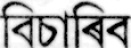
বিচাৰিব
